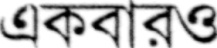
একবারও
